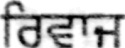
ਰਿਵਾਜ
